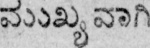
ಮುಖ್ಯವಾಗಿ
